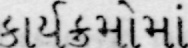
કાર્યક્રમોમાં
